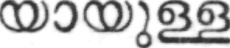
യായുള്ള
